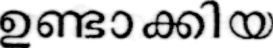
ഉണ്ടാക്കിയ
